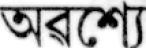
অৱশ্যে
